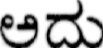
ಅದು
